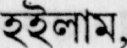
হইলাম,
